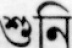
শুনি
